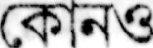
কোনও
